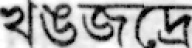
খঙজদ্রে
